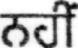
ਨਹੀਂ
